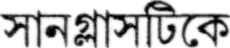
সানগ্লাসটিকে
